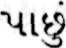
પાછું
